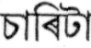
চাৰিটা
